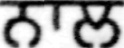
ਨਾਲ
